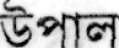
উপাল
